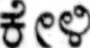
ಕೇಳಿ
